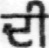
ਦੀ
